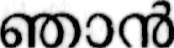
ഞാന്‍
